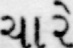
ચારે
